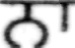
ਨਾ
